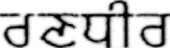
ਰਣਧੀਰ
